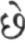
છે
